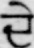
ਦੇ
